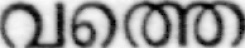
വത്തെ
